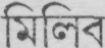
মিলিব
